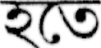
হতে
